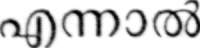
എന്നാല്‍
